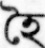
হৈ
